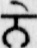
ਨੇ
